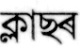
ক্লাছৰ
